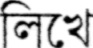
লিখে
